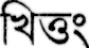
খিত্তং
